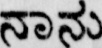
ನಾನು
